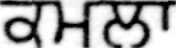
ਕਮਲਾ
